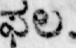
ಫಲ.
